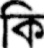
কি
